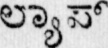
ಲ್ಯಾಪ್
